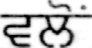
ਵਲੋਂ
